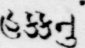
હક્કનું
